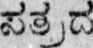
ಪತ್ರದ
